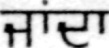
ਜਾਂਦਾ
